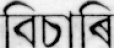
বিচাৰি
